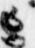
હું
